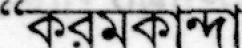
“করমকান্দা
